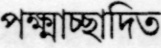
পক্ষ্মাচ্ছাদিত
